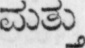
ಮತ್ತು
